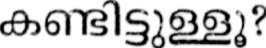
കണ്ടിട്ടുള്ളൂ?
